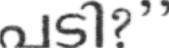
പടി?"
